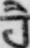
ਹੈ
